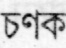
চণক
